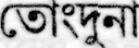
তোংদুনা
